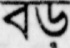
বড়
